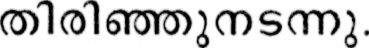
തിരിഞ്ഞുനടന്നു.
